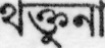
থক্তুনা
